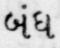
બંધ
